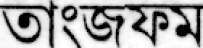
তাংজফম
